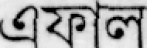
এফাল
